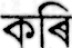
কৰি
